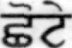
ਛੋਟੇ
